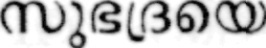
സുഭദ്രയെ
